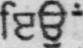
ਇਉਂ
